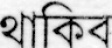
থাকিব
